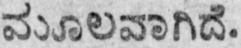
ಮೂಲವಾಗಿದೆ.
